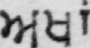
ਅਖਾਂ
